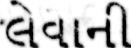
લેવાની
